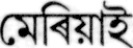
মেৰিয়াই
